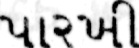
પારખી
